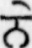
ਨੇ
